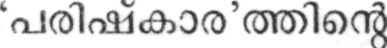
'പരിഷ്കാര'ത്തിന്റെ
